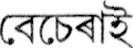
বেচেৰাই
